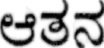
ಆತನ
